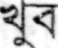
খুব
